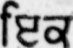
ਇਕ
